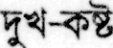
দুখ-কষ্ট
